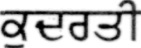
ਕੁਦਰਤੀ
